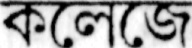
কলেজে
